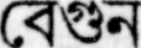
বেগুন
